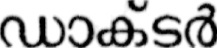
ഡാക്ടര്‍
